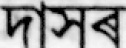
দাসৰ
